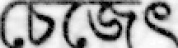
চেজেৎ
